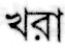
খরা
